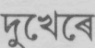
দুখেৰে
